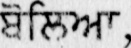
ਬੋਲਿਆ,
